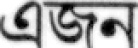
এজন
